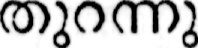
തുറന്നു
